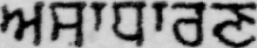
ਅਸਾਧਾਰਣ
